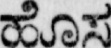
ಹೊಸ
